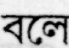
বলে
